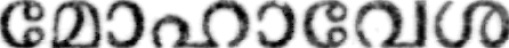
മോഹാവേശ
